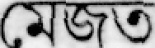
মেজত
